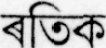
ৰতিক
